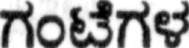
ಗಂಟೆಗಳ
